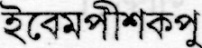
ইবেমপীশকপু
